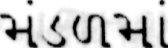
મંડળમાં
